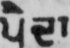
ਪੈਦਾ
